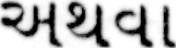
અથવા
